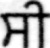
ਸੀ
